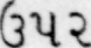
ઉપર
